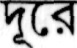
দূরে
